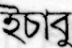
ইচাবু
